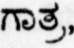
ಗಾತ್ರ,
